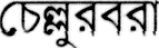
চেল্লুরবরা
